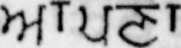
ਆਪਣਾ
